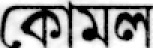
কোমল
